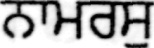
ਨਾਮਰਸੁ
